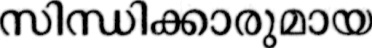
സിന്ധിക്കാരുമായ
